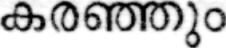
കരഞ്ഞും
